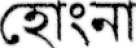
হোংনা
